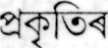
প্রকৃতিৰ
